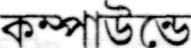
কম্পাউন্ডে
